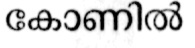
കോണില്‍
